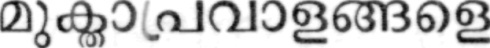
മുക്താപ്രവാളങ്ങളെ
